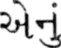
એનું
